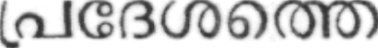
പ്രദേശത്തെ
